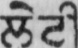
ਲੇਟੀ
